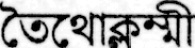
তৈথোক্লম্মী
